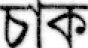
চাক
